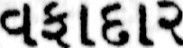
વફાદાર
